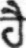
ਹੈ
